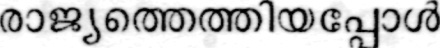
രാജ്യത്തെത്തിയപ്പോള്‍
